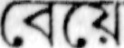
বেয়ে
